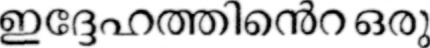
ഇദ്ദേഹത്തിന്റെഒരു
